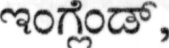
ಇಂಗ್ಲೆಂಡ್,
